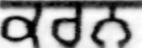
ਕਰਨ
